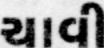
ચાવી
